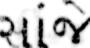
સાંજે
